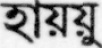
হায়য়ু
